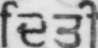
ਦਿਤੀ
